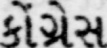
કોંગ્રેસ
